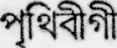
পৃথিবীগী
